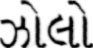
ઝોલો
